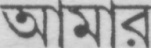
আমার
